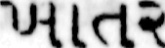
ખાતર
